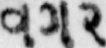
વગર
